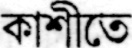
কাশীতে
